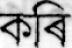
কৰি
